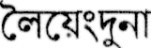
লৈয়েংদুনা
